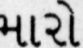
મારો
